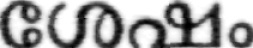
ശേഷം
